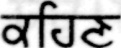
ਕਹਿਣ
